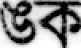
ঙক
